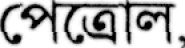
পেত্রোল,
